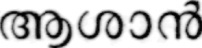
ആശാന്‍
